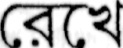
রেখে
